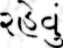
રહેવું
